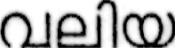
വലിയ
